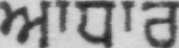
ਆਧਾਰ
